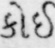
કોઈ
